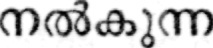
നല്‍കുന്ന
